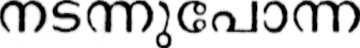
നടന്നുപോന്ന
